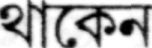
থাকেন
